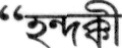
“হন্দক্কী
